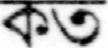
কত
